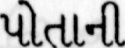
પોતાની
